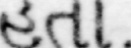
હતા.
